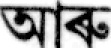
আৰু
